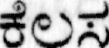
ಕೆಲಸ
